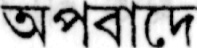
অপবাদে
